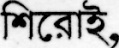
শিরোই,
